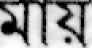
মায়
